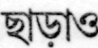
ছাড়াও
